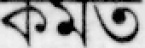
কমত
